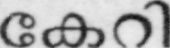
കേറി
